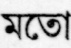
মতো
